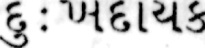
દુઃખદાયક
